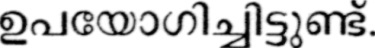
ഉപയോഗിച്ചിട്ടുണ്ട്.
